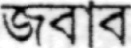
জবাব
